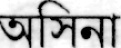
অসিনা
